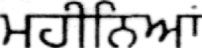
ਮਹੀਨਿਆਂ
